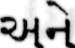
અને
